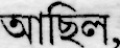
আছিল,
